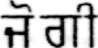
ਜੋਗੀ
